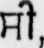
ਸੀ,
